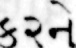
કરને
